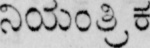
ನಿಯಂತ್ರಿಕ
